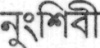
নুংশিবী
